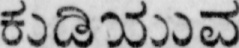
ಕುಡಿಯುವ
